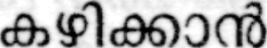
കഴിക്കാന്‍
